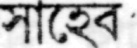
সাহেব
